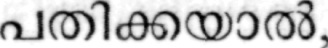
പതിക്കയാല്‍,
